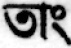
তাং
